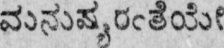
ಮನುಷ್ಯರಂತೆಯೇ
